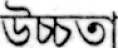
উচ্চতা
